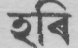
হৰি
